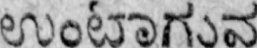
ಉಂಟಾಗುವ
